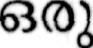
ഒരു
